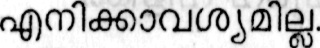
എനിക്കാവശ്യമില്ല.
